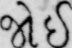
જોઈ
